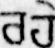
ਰਹੇ
